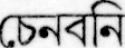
চেনবনি
